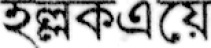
হল্লকএয়ে
